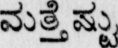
ಮತ್ತೆಷ್ಟು
